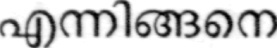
എന്നിങ്ങനെ
